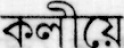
কলীয়ে
